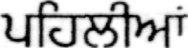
ਪਹਿਲੀਆਂ
